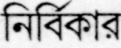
নির্বিকার
